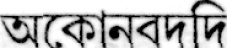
অকোনবদদি
